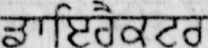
ਡਾਇਰੈਕਟਰ
